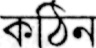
কঠিন
